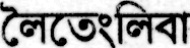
লৈতেংলিবা
